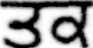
ਤਕ
